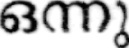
ഒന്നു
